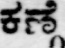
ಕಣ್ಗೆ
